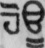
ਹੋਊ
